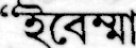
“ইবেম্মা
